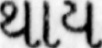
થાય
